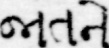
જાતને
